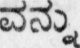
ವನ್ನು
